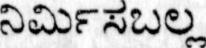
ನಿರ್ಮಿಸಬಲ್ಲ
